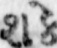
શકે
